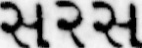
સરસ
